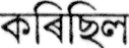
কৰিছিল
